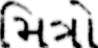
મિત્રો
